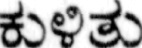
ಕುಳಿತು
